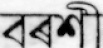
বৰশী
